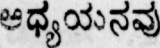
ಅಧ್ಯಯನವು
